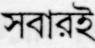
সবারই
